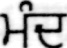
ਮੰਦ
